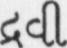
દ્રવી
